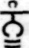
ਨੂੰ
